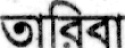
তারিবা
